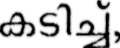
കടിച്ച്,
